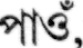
পাওঁ,
